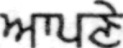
ਆਪਣੇ
